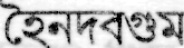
হৈনদবগুম
